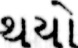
થયો
